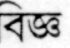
বিজ্ঞ
